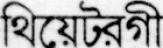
থিয়েটরগী
